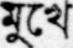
মুখে
